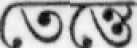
তেন্তে
